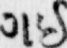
ગઈ
